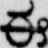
ಈ
